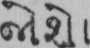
જોશો
